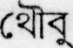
থৌবু
